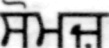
ਸੋਮਜ਼
